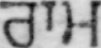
ਰਾਮ
